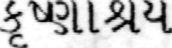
કૃષ્ણાશ્રય
